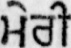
ਮੇਰੀ
